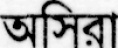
অসিরা
